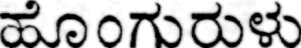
ಹೊಂಗುರುಳು
